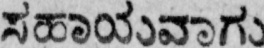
ಸಹಾಯವಾಗು
